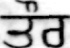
ਤੌਰ
